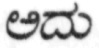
ಅದು
